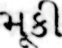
મૂકી
